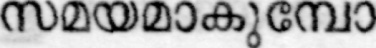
സമയമാകുമ്പോ
